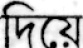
দিয়ে
